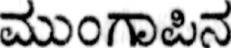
ಮುಂಗಾಪಿನ
